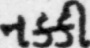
નક્કી
